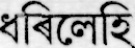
ধৰিলেহি
